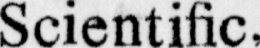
Scientific,
